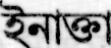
ইনাক্তা
